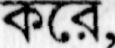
করে,
